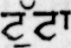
ਟੁੱਟਾ
